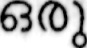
ഒരു
